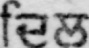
ਦਿਲ
